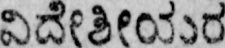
ವಿದೇಶೀಯರ
